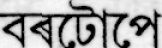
বৰটোপে
